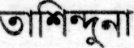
তাশিন্দুনা
